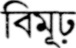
বিমূঢ়
